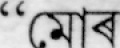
"মোৰ
